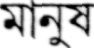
মানুষ
